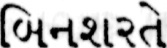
બિનશરતે
